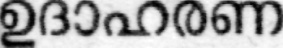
ഉദാഹരണ
